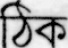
ঠিক
